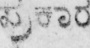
ಪ್ರಕಾರ
